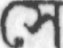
সে
